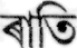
ৰাতি
